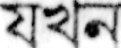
যখন
